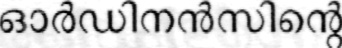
ഓര്‍ഡിനന്‍സിന്റെ
